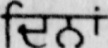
ਦਿਨਾਂ
